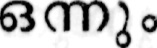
ഒന്നും
